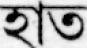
হাত
